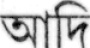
আদি
